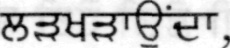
ਲੜਖੜਾਉਂਦਾ,
